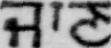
ਜਾਣ
